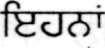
ਇਹਨਾਂ
